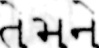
તેમને
